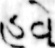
હવે
